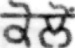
ਕੋਲੋਂ
